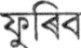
ফুৰিব
